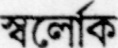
স্বর্লোক
